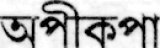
অপীকপা
